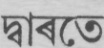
দ্বাৰতে
